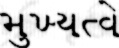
મુખ્યત્વે
